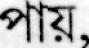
পায়,
